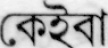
কেইবা
